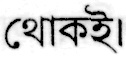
থোকই।
